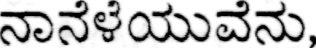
ನಾನೆಳೆಯುವೆನು,
